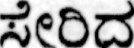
ಸೇರಿದ
